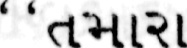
"તમારા
